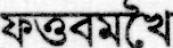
ফত্তবমখৈ
